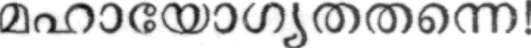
മഹായോഗ്യതതന്നെ!
